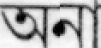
অনা
